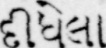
દીધેલા
